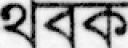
থবক
